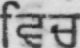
ਵਿਚ
